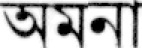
অমনা
